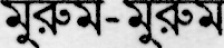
মুরুম-মুরুম
